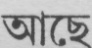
আছে
